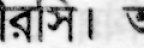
রসি
